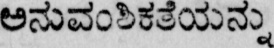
ಅನುವಂಶಿಕತೆಯನ್ನು
